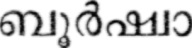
ബൂര്‍ഷ്വാ
